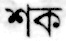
শক
